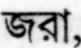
জরা,
